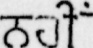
ਨਹੀਂ
